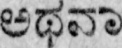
ಅಥವಾ
